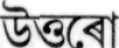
উত্তৰো
